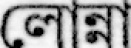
লোন্না
